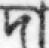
দা
